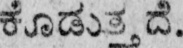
ಕೊಡುತ್ತದೆ.
